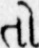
તો
